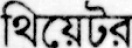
থিয়েটর
